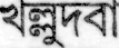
খল্লুদবা
